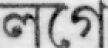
লগে
